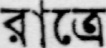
রাত্রে
